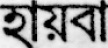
হায়বা
